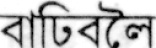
বাঢ়িবলৈ
